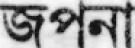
জপনা
